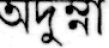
অদুম্না
